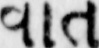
વાત
